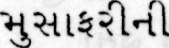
મુસાફરીની
